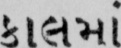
કાલમાં
